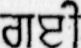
ਗਈ
